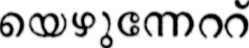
യെഴുന്നേററ്
